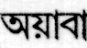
অয়াবা
